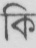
কি
